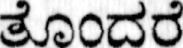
ತೊಂದರೆ
